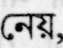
নেয়,
